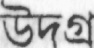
উদগ্র
